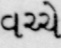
વચ્ચે
